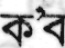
ক'ব
